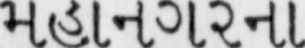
મહાનગરના
